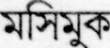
মসিমুক
